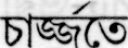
চাৰ্জ্জতে
